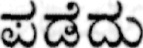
ಪಡೆದು
